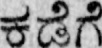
ಕಡೆಗೆ
